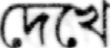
দেখে
